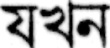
যখন
